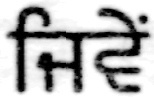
ਜਿਵੇਂ
